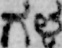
ಗಳ
